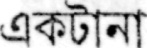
একটানা
